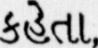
કહેતા,
